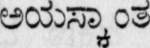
ಅಯಸ್ಕಾಂತ
